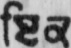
ਇਕ
